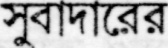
সুবাদারের
